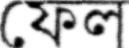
ফেল
